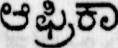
ಆಫ್ರಿಕಾ
